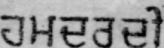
ਹਮਦਰਦੀ
